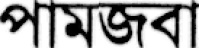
পামজবা
